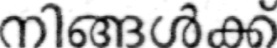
നിങ്ങള്‍ക്ക്
